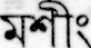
মশীং
